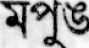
মপুঙ
